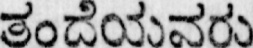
ತಂದೆಯವರು
